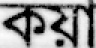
কয়া
